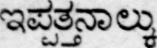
ಇಪ್ಪತ್ತನಾಲ್ಕು
